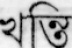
খন্তি
